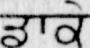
ਡਾਕੇ
